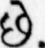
છે.
